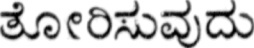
ತೋರಿಸುವುದು
